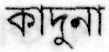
কাদুনা
